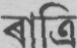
ৰাত্রি
